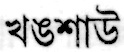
খঙশাউ
